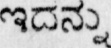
ಇದನ್ನು
